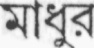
মাধুর
